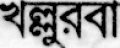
খল্লুরবা
